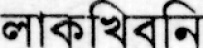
লাকখিবনি
